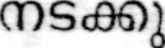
നടക്കു
